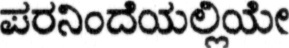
ಪರನಿಂದೆಯಲ್ಲಿಯೇ
